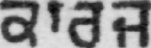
ਕਾਰਜ
